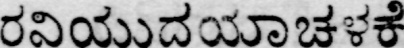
ರವಿಯುದಯಾಚಳಕೆ
